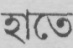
হাতে
